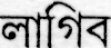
লাগিব
